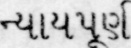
ન્યાયપૂર્ણ
